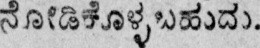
ನೋಡಿಕೊಳ್ಳಬಹುದು.
